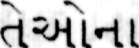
તેઓના
